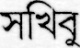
সখিবু
